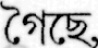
গৈছে,
